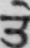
ਤੇ
